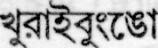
খুরাইবুংঙো
